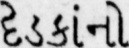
દેડકાંનો
